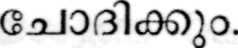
ചോദിക്കും.
